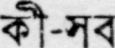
কী-সব
